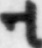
ન
